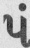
પં
